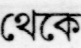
থেকে
